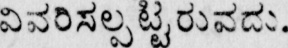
ವಿವರಿಸಲ್ಪಟ್ಟಿರುವದು.
